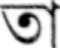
তা
